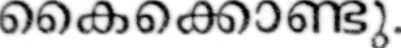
കൈക്കൊണ്ടു.
